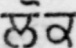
ਲੋਕ
